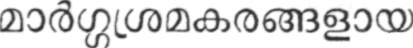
മാര്‍ഗ്ഗശ്രമകരങ്ങളായ
